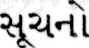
સૂચનો
